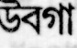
উবগা
